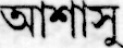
আশাসু
